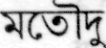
মতৌদু
